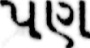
પણ
